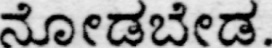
ನೋಡಬೇಡ.
